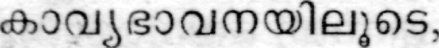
കാവ്യഭാവനയിലൂടെ,
